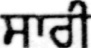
ਸਾਰੀ
